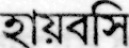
হায়বসি
